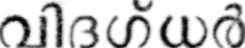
വിദഗ്ധര്‍
